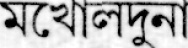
মখোলদুনা
